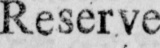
Reserve
